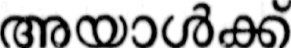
അയാള്‍ക്ക്
